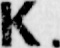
K.
